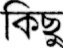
কিছু
